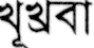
খূখ্রবা
